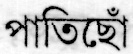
পাতিছোঁ
